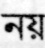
নয়
